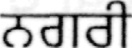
ਨਗਰੀ
